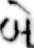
બે
